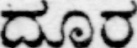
ದೂರ
